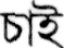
চাই
